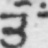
ਤੋਂ
